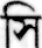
সি
